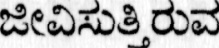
ಜೀವಿಸುತ್ತಿರುವ
